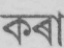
কৰা
